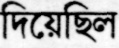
দিয়েছিল
